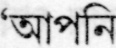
‘আপনি
